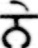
ਨੇ
